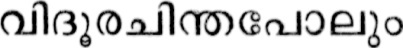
വിദൂരചിന്തപോലും
